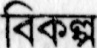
বিকল্প
